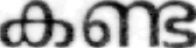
കണ്ട
